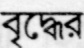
বৃদ্ধের
